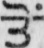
ਤੋਂ
